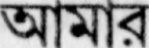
আমার
